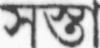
সস্তা
